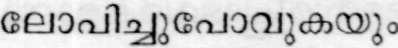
ലോപിച്ചുപോവുകയും
